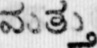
ಮತ್ತು
